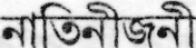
নাতিনীজনী
